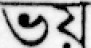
ভয়
